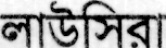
লাউসিরা
